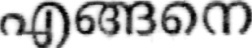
എങ്ങനെ
